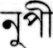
নুপী
